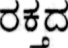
ರಕ್ತದ
